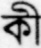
কী
